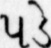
પડે
